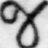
જ
